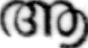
ആ
